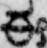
ಈ
